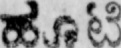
ಹೂಟೆ
